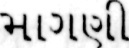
માગણી
